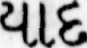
યાદ
